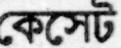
কেসেট
